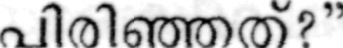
പിരിഞ്ഞത്?”
